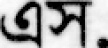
এস.
